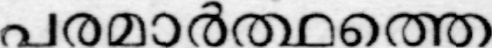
പരമാര്‍ത്ഥത്തെ
